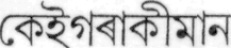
কেইগৰাকীমান
